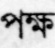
পক্ষ
